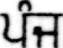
ਪੰਜ
